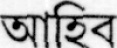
আহিব
